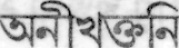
অনীখক্তনি
